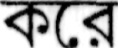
করে
